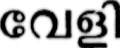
വേളി
